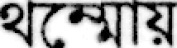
থম্মোয়
